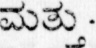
ಮತ್ತು.
